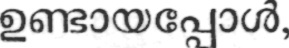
ഉണ്ടായപ്പോള്‍,
